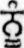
ਨੂੰ
